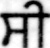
ਸੀ
